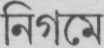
নিগমে
